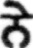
ਨੇ
